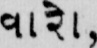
વારો,
